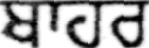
ਬਾਹਰ
